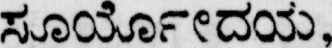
ಸೂರ್ಯೋದಯ,
